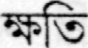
ক্ষতি
